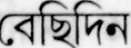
বেছিদিন
